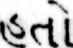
હતો
